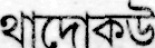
থাদোকউ
